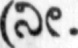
(ನೀ.
